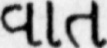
વાત
